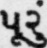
પૂરું
